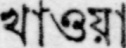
খাওয়া
